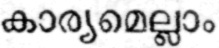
കാര്യമെല്ലാം
